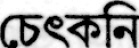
চেৎকনি
